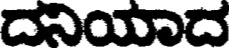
ದನಿಯಾದ
